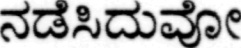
ನಡೆಸಿದುವೋ
